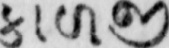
કાળજી
